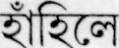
হাঁহিলে
